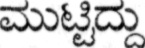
ಮುಟ್ಟಿದ್ದು
